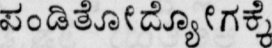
ಪಂಡಿತೋದ್ಯೋಗಕ್ಕೆ
